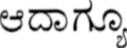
ಆದಾಗ್ಯೂ
